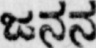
ಜನನ
